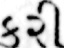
કરી
